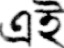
এই
